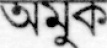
অমুক
